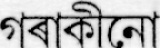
গৰাকীনো
